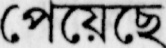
পেয়েছে
